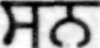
ਸਨ
